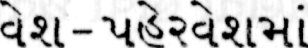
વેશ-પહેરવેશમાં
